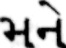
મને
